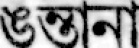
ঙন্তানা
